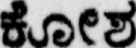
ಕೋಶ
